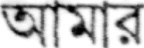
আমার
